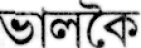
ভালকৈ
